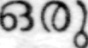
ഒരു
